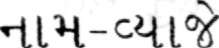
નામ-વ્યાજે
